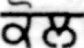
ਕੋਲ
